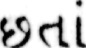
છતાં
